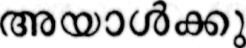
അയാള്‍ക്കു
